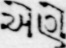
એણે
